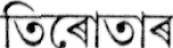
তিৰোতাৰ
